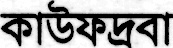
কাউফদ্রবা
